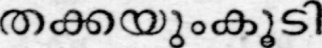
തക്കയുംകൂടി
